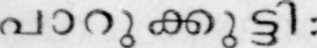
പാറുക്കുട്ടി:
